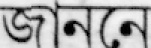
জাননে
